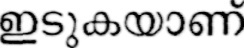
ഇടുകയാണ്
